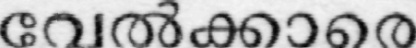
വേല്‍ക്കാരെ
